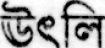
ঊৎলি
